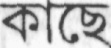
কাছে
